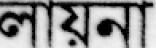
লায়না
